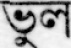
ভুল
